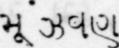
મૂંઝવણ
